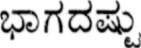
ಭಾಗದಷ್ಟು
